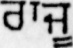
ਰਾਜੂ
